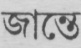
জান্তে
